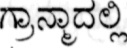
ಗ್ರಾನ್ಮಾದಲ್ಲಿ
